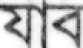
যাব
